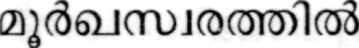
മൂര്‍ഖസ്വരത്തില്‍
